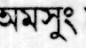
অমসুং
